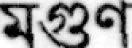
মগুণ
